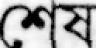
শেষ
